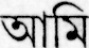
আমি
